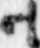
ન
